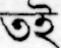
তই
